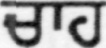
ਚਾਹ
